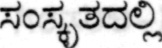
ಸಂಸ್ಕೃತದಲ್ಲಿ
